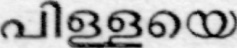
പിള്ളയെ
